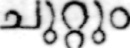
ചുറ്റും
